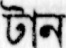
টান
